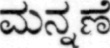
ಮನ್ನಣೆ
